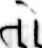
તો
